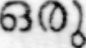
ഒരു
